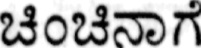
ಚಿಂಚಿನಾಗೆ
